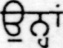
ਉਨ੍ਹਾਂ
